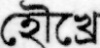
হৌখ্রে
